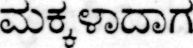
ಮಕ್ಕಳಾದಾಗ
